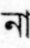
না
